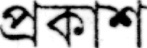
প্রকাশ
